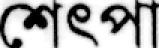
শেৎপা
